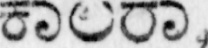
ಕಾಲರಾ,
